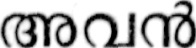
അവന്‍
